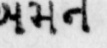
અમને
